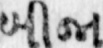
બીજા
